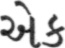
એક
